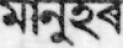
মানুহৰ
